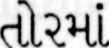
તોરમાં
